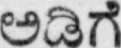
ಅಡಿಗೆ
